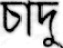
চাদু
